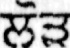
ਲੋੜ
